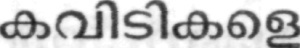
കവിടികളെ
